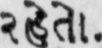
રહેતો.
